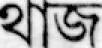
থাজ
